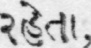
રહેતા,
